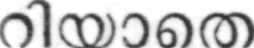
റിയാതെ
